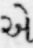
એ
